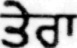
ਤੇਰਾ
